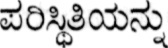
ಪರಿಸ್ಥಿತಿಯನ್ನು
